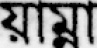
য়াম্না
